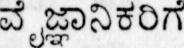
ವೈಜ್ಞಾನಿಕರಿಗೆ
